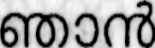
ഞാന്‍
